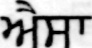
ਐਸਾ
